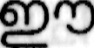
ഈ
